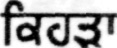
ਕਿਹੜਾ
